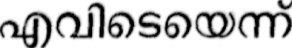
എവിടെയെന്ന്
